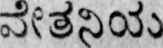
ವೇತನಿಯ
